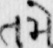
તમે
